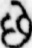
છે
